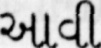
આવી
